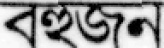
বহুজন
